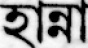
হান্না
